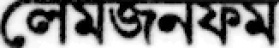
লেমজনফম
